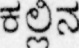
ಕಲ್ಲಿನ
